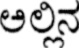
ಅಲ್ಲಿನ
